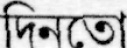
দিনতো
